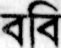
ববি
